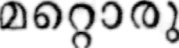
മറ്റൊരു
